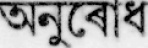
অনুৰোধ
